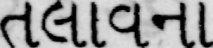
તલાવના
